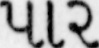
પાર
